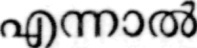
എന്നാല്‍
